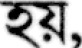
হয়,
